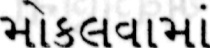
મોકલવામાં
